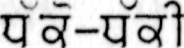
ਧੱਕੋ-ਧੱਕੀ
